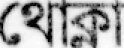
থোক্না
